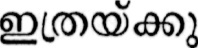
ഇത്രയ്ക്കു
